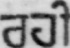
ਰਹੀ
